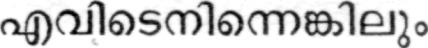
എവിടെനിന്നെങ്കിലും
